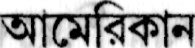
আমেরিকান
